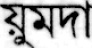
য়ুমদা
